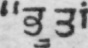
''ਭੂਤਾਂ
